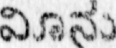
ಮೀನು
